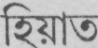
হিয়াত
